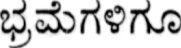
ಭ್ರಮೆಗಳಿಗೂ
